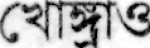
খোঙ্গ্রাও
